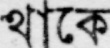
থাকে
